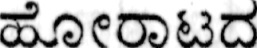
ಹೋರಾಟದ
